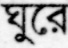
ঘুরে
